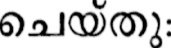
ചെയ്തു:
